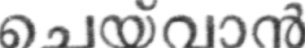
ചെയ്വാന്‍
